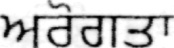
ਅਰੋਗਤਾ
